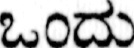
ಒಂದು
